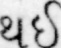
થઈ
